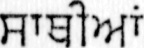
ਸਾਥੀਆਂ
